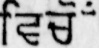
ਵਿਚੋਂ
